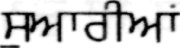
ਸੁਆਰੀਆਂ
